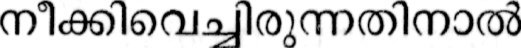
നീക്കിവെച്ചിരുന്നതിനാല്‍
